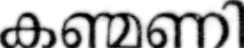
കണ്മണി
